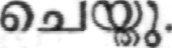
ചെയ്തു.
